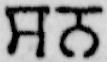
ਸਨ
